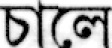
চালে
